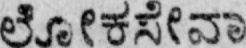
ಲೋಕಸೇವಾ
